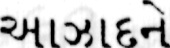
આઝાદને
